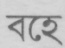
বহে
